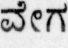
ವೇಗ
